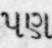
પણ
